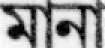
মানা
